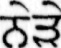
ਨੇੜੇ
